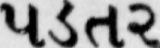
પડતર
